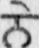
ਨੇ
